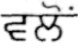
ਵਲੋਂ
